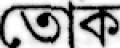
তোক
